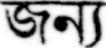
জন্য
